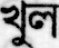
খুল
